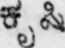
ಕೃಷಿ
